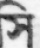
সি
